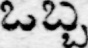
ಒಬ್ಬ
